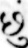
છું
